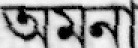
অমনা
